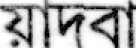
য়াদবা
